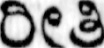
ರೀತಿ
